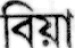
বিয়া
